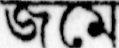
জমে
